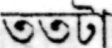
ততটা
